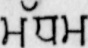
ਮੱਧਮ
